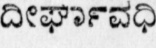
ದೀರ್ಘಾವಧಿ
